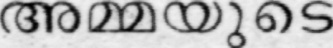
അമ്മയുടെ
